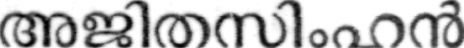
അജിതസിംഹന്‍
